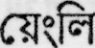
য়েংলি
